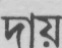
দায়
